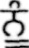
ਨੂੰ
